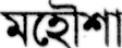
মহৌশা
